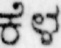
ಕೆಳ
